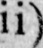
ii)
